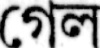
গেল
